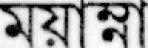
ময়াম্না
